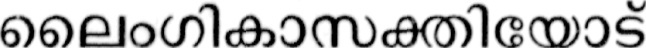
ലൈംഗികാസക്തിയോട്
